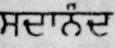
ਸਦਾਨੰਦ
